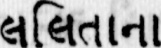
લલિતાના
